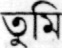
তুমি
